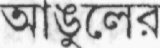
আঙুলের
